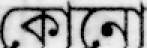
কোনো
